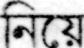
নিয়ে
